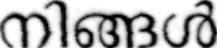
നിങ്ങള്‍
